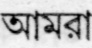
আমরা
